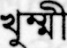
খুম্মী
